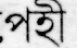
পেইী
